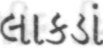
લાકડાં
